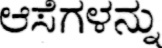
ಆಸೆಗಳನ್ನು
